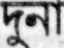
দুনা
